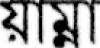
য়াম্না
